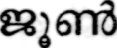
ജൂണ്‍
